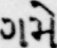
ગમે
